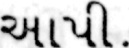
આપી.
